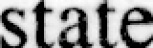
state
